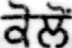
ਕੋਲੋਂ
